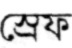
স্রেফ
